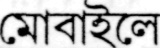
মোবাইলে
